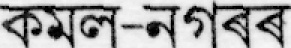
কমল-নগৰৰ
